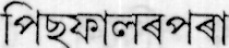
পিছফালৰপৰা
